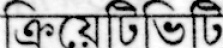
ক্রিয়েটিভিটি
